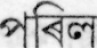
পৰিল
